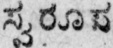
ಸ್ವರೂಪ
